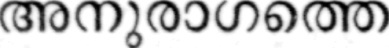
അനുരാഗത്തെ
